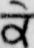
ਕੇ
